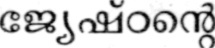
ജ്യേഷ്ഠന്റെ
